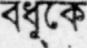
বধূকে
